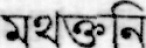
মথক্তনি
